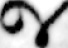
જ
